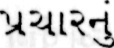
પ્રચારનું
